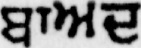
ਬਾਅਦ
